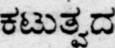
ಕಟುತ್ವದ
